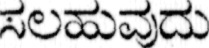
ಸಲಹುವುದು
